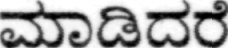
ಮಾಡಿದರೆ
